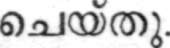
ചെയ്തു.
